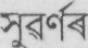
সুৱৰ্ণৰ
